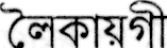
লৈকায়গী
